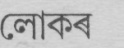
লোকৰ
